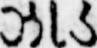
ઝાડ
